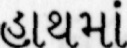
હાથમાં
